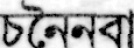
চনৈনবা
